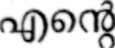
എന്റെ
